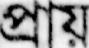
প্রায়
